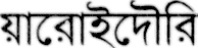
য়ারোইদৌরি
